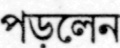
পড়লেন
